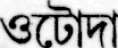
ওটোদা
